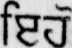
ਇਹੋ
